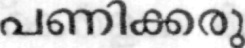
പണിക്കരു
